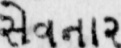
સેવનાર
